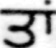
ਤਾਂ
